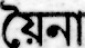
য়ৈনা
